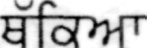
ਥੱਕਿਆ
